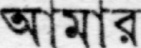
আমার
